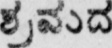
ಶ್ರಮದ
